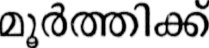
മൂര്‍ത്തിക്ക്
